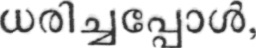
ധരിച്ചപ്പോള്‍,
